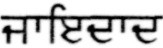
ਜਾਇਦਾਦ
